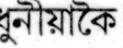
ধুনীয়াকৈ
